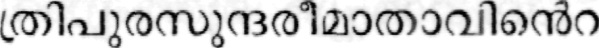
ത്രിപുരസുന്ദരീമാതാവിന്റെ
